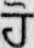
ਹੋ
